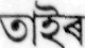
তাইৰ
